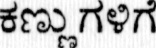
ಕಣ್ಣುಗಳಿಗೆ
